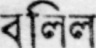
বলিল
